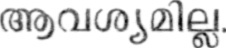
ആവശ്യമില്ല.
